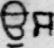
ਉਸ
